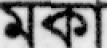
মকা
